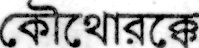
কৌথোরক্কে
